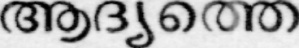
ആദ്യത്തെ
